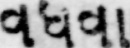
વધવા
